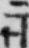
ਜੋ
